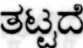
ತಟ್ಟದೆ
